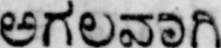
ಅಗಲವಾಗಿ
